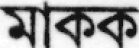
মাকক
